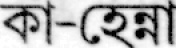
কা-হেন্না
